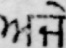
ਅਜੇ
